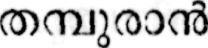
തമ്പുരാന്‍
